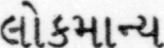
લોકમાન્ય
